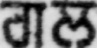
ਗਲ
